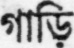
গাড়ি
